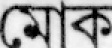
মোক
